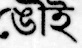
ঙৌই
